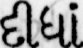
દીધાં
